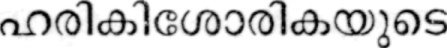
ഹരികിശോരികയുടെ
